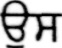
ਉਸ
